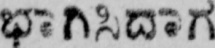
ಭಾಗಿಸಿದಾಗ
